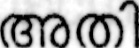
അതി
